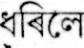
ধৰিলে
